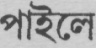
পাইলে
